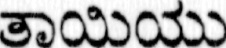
ತಾಯಿಯು
